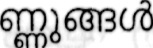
ണ്ണുങ്ങള്‍
